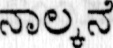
ನಾಲ್ಕನೆ
